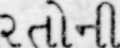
રતોની
